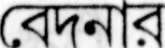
বেদনার
